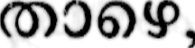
താഴെ,
